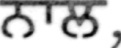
ਨਾਲ,
